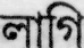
লাগি
